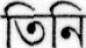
তিনি
